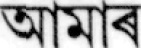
আমাৰ
